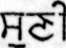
ਸੁਣੀ
